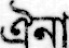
ঐনা
